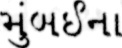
મુંબઈના
